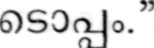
ടൊപ്പം."
